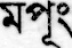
মপূং
